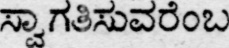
ಸ್ವಾಗತಿಸುವರೆಂಬ
